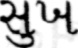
સુખ
